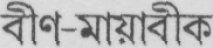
বীণ-মায়াবীক
